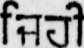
ਜਿਹੀ
